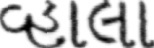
વ્હાલા
